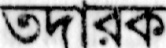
তদারক
